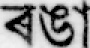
ৰঙা
